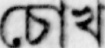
চোখ
